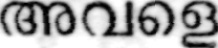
അവളെ
